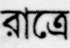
রাত্রে
